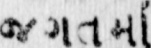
જગતમાં
